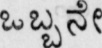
ಒಬ್ಬನೇ
